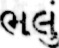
ભલું
